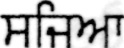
ਸਜਿਆ
